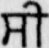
ਸੀ
